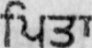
ਪਿਤਾ
